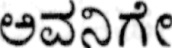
ಅವನಿಗೇ
